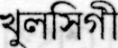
খুলসিগী
